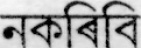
নকৰিবি
